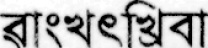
ৱাংখৎখ্রিবা
